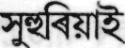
সুহুৰিয়াই
